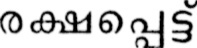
രക്ഷപ്പെട്ട്
